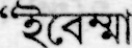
“ইবেম্মা
